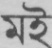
মই
